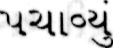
પચાવ્યું
